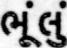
ભૂંલુ
